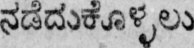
ನಡೆದುಕೊಳ್ಳಲು
